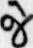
જે
